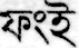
ফংই
